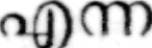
എന്ന
